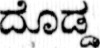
ದೊಡ್ಡ
